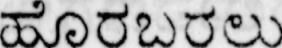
ಹೊರಬರಲು
